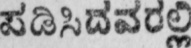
ಪಡಿಸಿದವರಲ್ಲಿ
